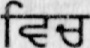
ਵਿਚ
